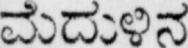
ಮೆದುಳಿನ
